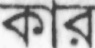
কার
